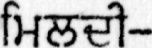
ਮਿਲਦੀ-
